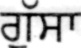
ਗੁੱਸਾ
